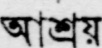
আশ্রয়
